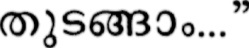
തുടങ്ങാം...”
